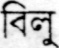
বিলু
